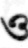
ও
